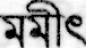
মমীৎ
